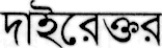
দাইরেক্তর
